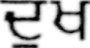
ਦੁਖ
